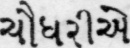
ચૌધરીએ
